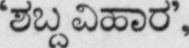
‘ಶಬ್ದವಿಹಾರ’,
